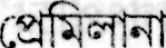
প্রেমিলানা
